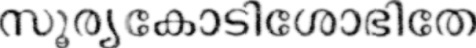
സൂര്യകോടിശോഭിതേ
